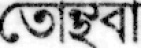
তোন্থবা
